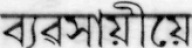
ব্যৱসায়ীয়ে
